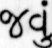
જવું
